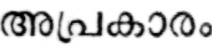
അപ്രകാരം
